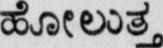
ಹೋಲುತ್ತ
